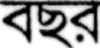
বছর
